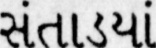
સંતાડયાં
